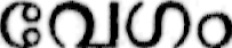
വേഗം
